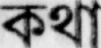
কথা
